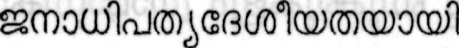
ജനാധിപത്യദേശീയതയായി
